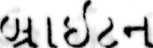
બ્રાઈટન
